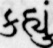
કહ્યું
